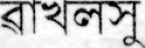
ৱাখলসু
